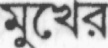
মুখের
